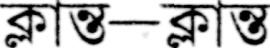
ক্লান্ত–ক্লান্ত
